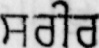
ਸਰੀਰ
